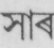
সাৰ
